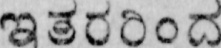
ಇತರರಿಂದ
